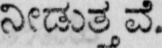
ನೀಡುತ್ತವೆ.
